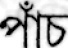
পাঁচ
